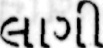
લાગી
